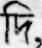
দি,
